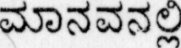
ಮಾನವನಲ್ಲಿ
